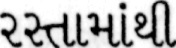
રસ્તામાંથી
